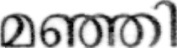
മഞ്ഞി
